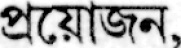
প্রয়োজন,
